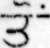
ਤੋਂ
